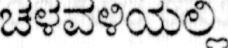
ಚಳವಳಿಯಲ್ಲಿ
